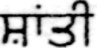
ਸ਼ਾਂਤੀ
